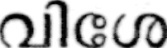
വിശേ
